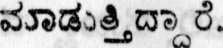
ಮಾಡುತ್ತಿದ್ದಾರೆ.
